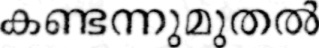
കണ്ടന്നുമുതല്‍
